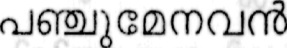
പഞ്ചുമേനവന്‍
